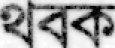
থবক
